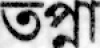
তপ্না
